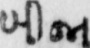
બીજા
